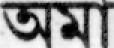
অমা
